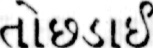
તોછડાઈ
